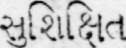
સુશિક્ષિત
